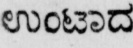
ಉಂಟಾದ
